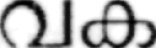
വക
